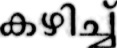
കഴിച്ച്
